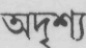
অদৃশ্য
